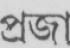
প্রজা
